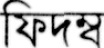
ফিদম্বু
